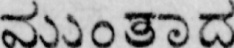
ಮುಂತಾದ
